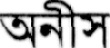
অনীসু
